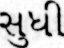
સુધી
